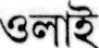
ওলাই
